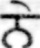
ਨੇ
